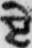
ਏ
